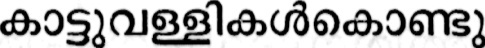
കാട്ടുവള്ളികള്‍കൊണ്ടു
